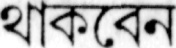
থাকবেন
